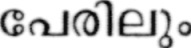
പേരിലും
